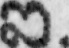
ಐ.
